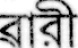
ৱারী
